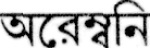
অরেম্বনি
